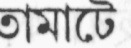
তামাটে
